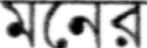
মনের
